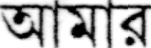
আমার
